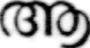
ആ
